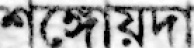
শঙ্গোয়দা
